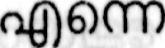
എന്നെ
